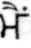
ਮੈਂ
